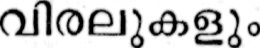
വിരലുകളും
